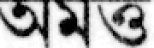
অমত্ত
